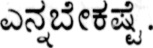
ಎನ್ನಬೇಕಷ್ಟೆ.
